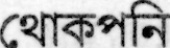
থোকপনি
